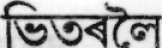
ভিতৰলৈ
